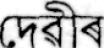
দেৱীৰ
